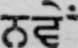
ਨਵੇਂ
